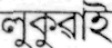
লুকুৱাই
